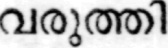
വരുത്തി
